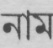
নাম
